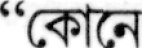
"কোনে
